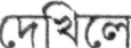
দেখিলে
